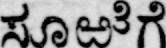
ಸೂಱೆಗೆ
